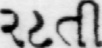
રટતી
